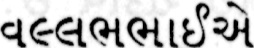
વલ્લભભાઈએ
